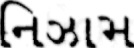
નિઝામ
